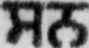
ਸਨ
